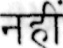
नहीं
